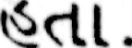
હતા.
